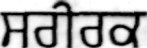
ਸਰੀਰਕ
